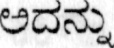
ಅದನ್ನು
